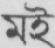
মই
